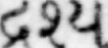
દ્રશ્ય
